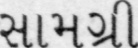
સામગ્રી
